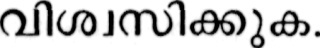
വിശ്വസിക്കുക.
